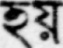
হয়
